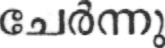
ചേര്‍ന്നു
